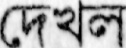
দেখল
